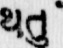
થતું
